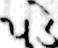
પડે
